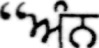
''ਅੰਨ
